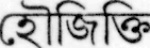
হৌজিক্তি
